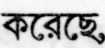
করেছে,
